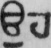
ਉਹ
